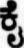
ಕೈ
